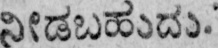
ನೀಡಬಹುದು.
